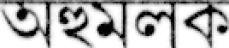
অহুমলক
